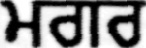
ਮਗਰ
